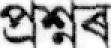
প্রশ্নৰ
